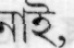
নাই,
